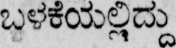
ಬಳಕೆಯಲ್ಲಿದ್ದು
